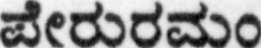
ಪೇರುರಮಂ
